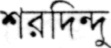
শরদিন্দু
